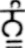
ਨੂੰ
